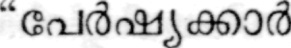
“പേര്‍ഷ്യക്കാര്‍
